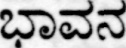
ಭಾವನ
